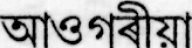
আওগৰীয়া
